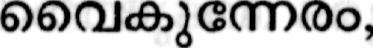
വൈകുന്നേരം,
